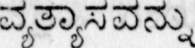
ವ್ಯತ್ಯಾಸವನ್ನು
